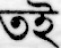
তই
